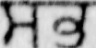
ਸਭ
